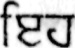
ਇਹ
